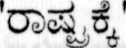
‘ರಾಷ್ಟ್ರಕ್ಕೆ’
